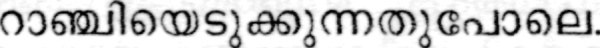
റാഞ്ചിയെടുക്കുന്നതുപോലെ.
